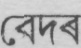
বেদৰ
